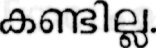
കണ്ടില്ല.
